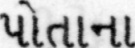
પોતાના
